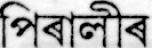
পিৰালীৰ
